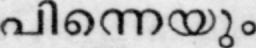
പിന്നെയും
